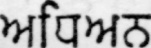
ਅਧਿਅਨ
